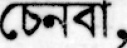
চেনবা,
